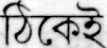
ঠিকেই
